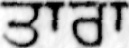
ਤਾਰਾ
